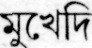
মুখেদি
